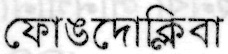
ফোঙদোক্লিবা
